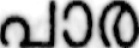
പാര
